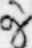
જે
